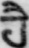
ਹੈ
